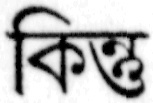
কিন্তু
